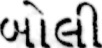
બોલી
